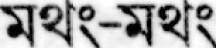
মথং-মথং
